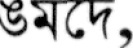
ঙমদে,
